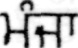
ਮੰਜਾ
